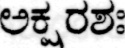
ಅಕ್ಷರಶಃ
